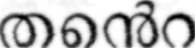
തന്റെ
